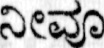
ನೀವೂ
